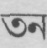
তন
